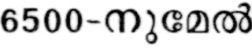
6500-നുമേല്‍
